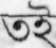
তই
